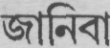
জানিবা
